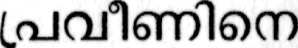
പ്രവീണിനെ
